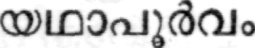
യഥാപൂര്‍വം
